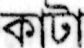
কাটা
